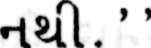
નથી."
